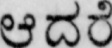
ಆದರೆ
